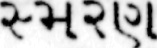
સ્મરણ
